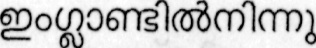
ഇംഗ്ലാണ്ടില്‍നിന്നു
